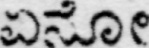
ಏನೋ
